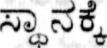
ಸ್ಥಾನಕ್ಕೆ
